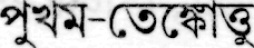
পুখম-তেঙ্কোত্তু
